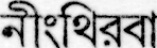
নীংথিরবা
